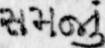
સમજું
